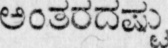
ಅಂತರದಷ್ಟು
